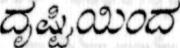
ದೃಷ್ಟಿಯಿಂದ
